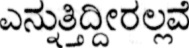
ಎನ್ನುತ್ತಿದ್ದೀರಲ್ಲವೆ
